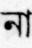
না
